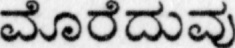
ಮೊರೆದುವು
